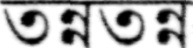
তন্নতন্ন
